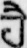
ਹੈ
